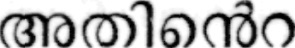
അതിന്റെ
